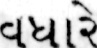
વધારે
